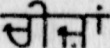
ਚੀਜ਼ਾਂ
